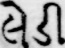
લેડી
